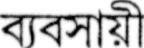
ব্যবসায়ী
